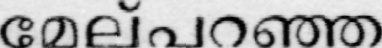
മേല്പറഞ്ഞ
